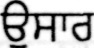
ਉਸਾਰ
